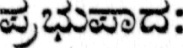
ಪ್ರಭುಪಾದ:
